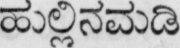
ಹುಲ್ಲಿನಮಡಿ
